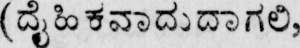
(ದೈಹಿಕವಾದುದಾಗಲಿ,
